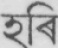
হৰি
